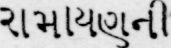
રામાયણની
